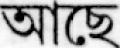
আছে
